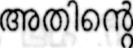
അതിന്റെ
